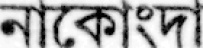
নাকোংদা
